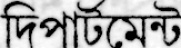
দিপার্টমেন্ট
